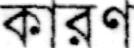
কারণ
